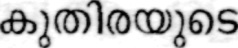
കുതിരയുടെ
